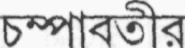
চম্পাবতীর
